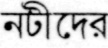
নটীদের
